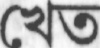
খেত
